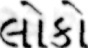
લોકો
